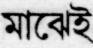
মাঝেই
